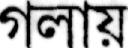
গলায়
